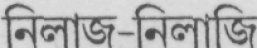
নিলাজ-নিলাজি
